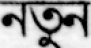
নতুন
